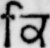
ਕਿ
